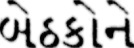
બેઠકોને
